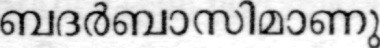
ബദര്‍ബാസിമാണു
